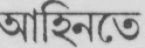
আহিনতে
